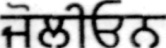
ਜੋਲੀਓਨ
